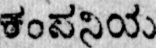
ಕಂಪನಿಯ
